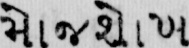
મોજશોખ
